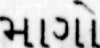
માગો
